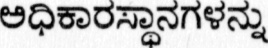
ಅಧಿಕಾರಸ್ಥಾನಗಳನ್ನು
